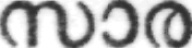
സാര
